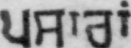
ਪਸਾਰਾਂ
